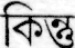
কিন্তু
